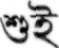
শুই
